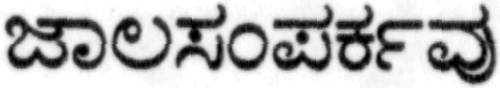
ಜಾಲಸಂಪರ್ಕವು
